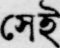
সেই
